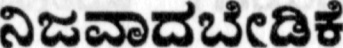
ನಿಜವಾದಬೇಡಿಕೆ
